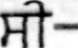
ਸੀ-
